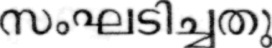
സംഘടിച്ചതു
